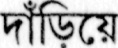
দাঁড়িয়ে
